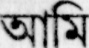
আমি
